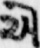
એ
